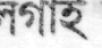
লগাই
